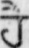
ਹੈ
